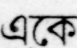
একে
